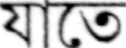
যাতে
